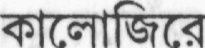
কালোজিরে
